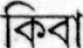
কিবা
